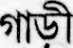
গাড়ী
